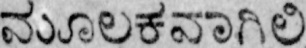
ಮೂಲಕವಾಗಿಲಿ
